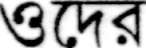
ওদের
